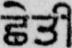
ਛੇਤੀ
